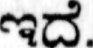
ಇದೆ.
